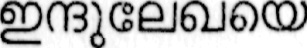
ഇന്ദുലേഖയെ
